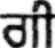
ਗੀ
